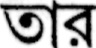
তার
